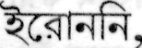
ইরোননি,
